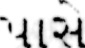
પાસે
